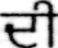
ਦੀ
